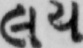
લય
